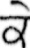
ਕੇ
